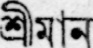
শ্রীমান
